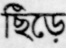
ছিঁড়ে
